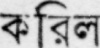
করিল
